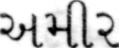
અમીર
